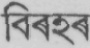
বিৰহৰ
